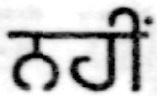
ਨਹੀਂ
